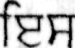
ਇਸ
